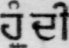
ਹੁੰਦੀ
